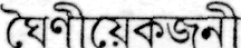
ঘৈণীয়েকজনী
